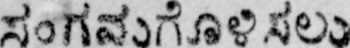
ಸಂಗಮಗೊಳಿಸಲು
